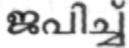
ജപിച്ച്
